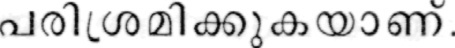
പരിശ്രമിക്കുകയാണ്.
